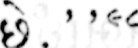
છે."૯૮
